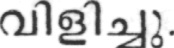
വിളിച്ചു.
